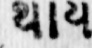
થાય
